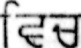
ਵਿਚ
